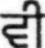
ਵੀ
